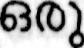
ഒരു
